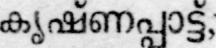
കൃഷ്ണപ്പാട്ട്,
